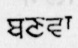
ਬਣਵਾ
